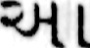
આ
